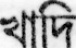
খাদি
